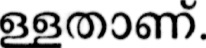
ള്ളതാണ്.
